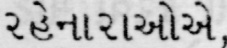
રહેનારાઓએ,
